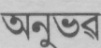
অনুভৱ
